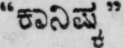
“ಕಾನಿಷ್ಕ”
